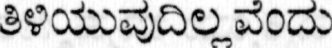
ತಿಳಿಯುವುದಿಲ್ಲವೆಂದು
